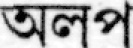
অলপ
